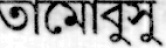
তামোবুসু
